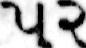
પર
